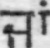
ਜਾਂ
